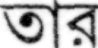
তার
